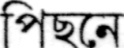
পিছনে
